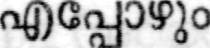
എപ്പോഴും
